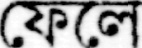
ফেলে
